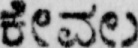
ಕೇವಲ
